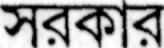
সরকার
